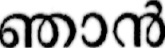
ഞാന്‍
